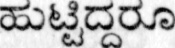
ಹುಟ್ಟಿದ್ದರೂ
